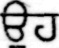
ਉਹ
